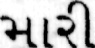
મારી
